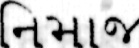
નિમાજ
